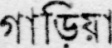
গাড়িয়া
